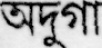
অদুগা
